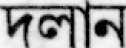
দলান
